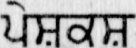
ਪੇਸ਼ਕਸ਼
